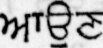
ਆਉਣ
